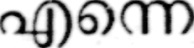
എന്നെ
